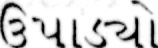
ઉપાડ્યો
